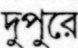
দুপুরে
